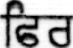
ਫਿਰ
